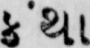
કંથા
